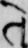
તે
